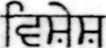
ਵਿਸ਼ੇਸ਼
